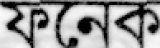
ফনেক
